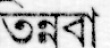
তিন্নবা
